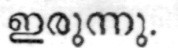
ഇരുന്നു.
